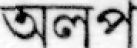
অলপ
